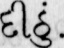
દીઠું.
